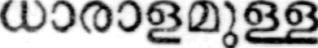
ധാരാളമുള്ള
